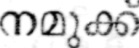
നമുക്ക്
